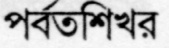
পর্বতশিখর
